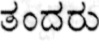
ತಂದರು
